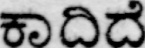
ಕಾದಿದೆ
